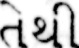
તેથી
